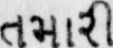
તમારી
